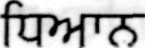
ਧਿਆਨ
